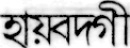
হায়বদগী
